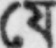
যে
